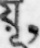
য়ূ,
